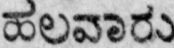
ಹಲವಾರು
